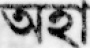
অহা
